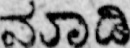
ಮಾಡಿ
